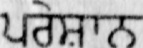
ਪਰੇਸ਼ਾਨ
